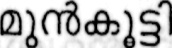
മുന്‍കൂട്ടി
